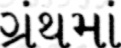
ગ્રંથમાં
